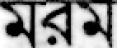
মরম
